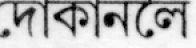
দোকানলৈ
